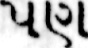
પણ
